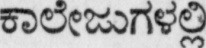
ಕಾಲೇಜುಗಳಲ್ಲಿ
